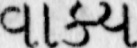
વાક્ય
